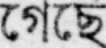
গেছে
